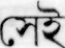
সেই
